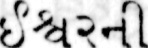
ઈશ્વરની
